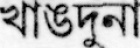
খাঙদুনা
